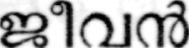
ജീവന്‍
